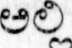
ಅಲ್ಲಿ
